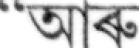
"আৰু
